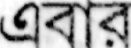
এবার
